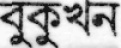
বুকুখন
